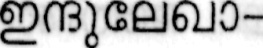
ഇന്ദുലേഖാ-
